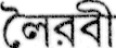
লৈরবী
